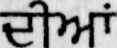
ਦੀਆਂ
